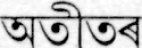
অতীতৰ
